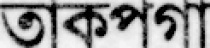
তাকপগা
